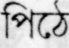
পিঠে
